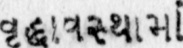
વૃદ્ધાવસ્થામાં
